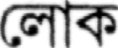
লোক
